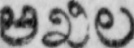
ಅಖಿಲ
